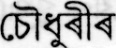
চৌধুৰীৰ
